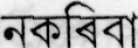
নকৰিবা
